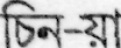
চিন-য়া
